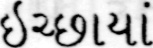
ઈચ્છાયાં
